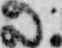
ವಿ.
